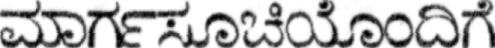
ಮಾರ್ಗಸೂಚಿಯೊಂದಿಗೆ
